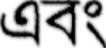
এবং
